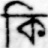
কি
